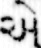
એ
